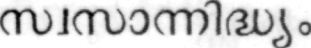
സ്വസാന്നിദ്ധ്യം
